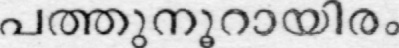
പത്തുനൂറായിരം
